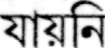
যায়নি
